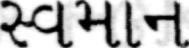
સ્વમાન
